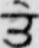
ਤੇ
